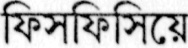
ফিসফিসিয়ে
